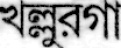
খল্লুরগা
